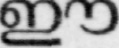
ഈ
